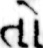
તો
